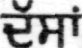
ਦੱਸਾਂ
